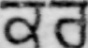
ਕਰ
